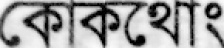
কোকথোং
